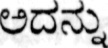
ಅದನ್ನು
